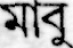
মাবু
